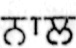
ਨਾਲ
